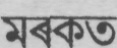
মৰকত
